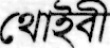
থোইবী
